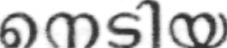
നെടിയ
